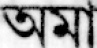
অমা
